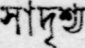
সাদৃশ্য
